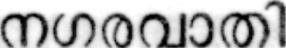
നഗരവാതി
